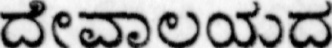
ದೇವಾಲಯದ
